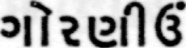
ગોરણીઉં
